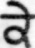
ਕੇ
